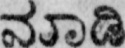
ಮಾಡಿ
